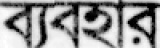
ব্যবহার
